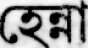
হেন্না
